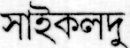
সাইকলদু
